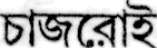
চাজরোই
